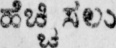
ಹೆಚ್ಚಿಸಲು
